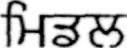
ਮਿਡਲ
